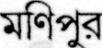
মণিপুর
